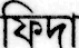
ফিদা
